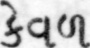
કેવળ
